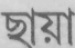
ছায়া
